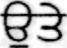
ਉਤੇ
